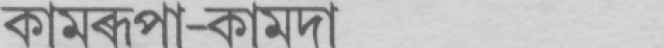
কামৰূপা-কামদা
